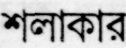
শলাকার
